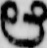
ಆ
